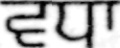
ਵਧਾ
